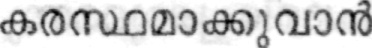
കരസ്ഥമാക്കുവാന്‍
